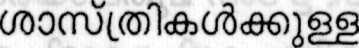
ശാസ്ത്രികള്‍ക്കുള്ള
